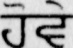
ਹੋਵੇ
